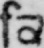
ਕਿ
